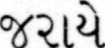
જરાયે
